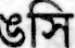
ঙসি
